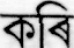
কৰি
